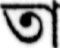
তা
